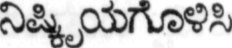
ನಿಷ್ಕ್ರಿಯಗೊಳಿಸಿ
